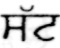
ਸੱਟ
